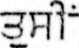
ਤੁਸੀਂ
